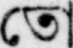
তো
